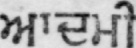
ਆਦਮੀ
